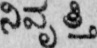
ನಿವೃತ್ತಿ
